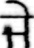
ਜੇ
